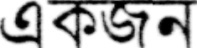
একজন
